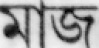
মাজ
